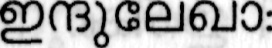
ഇന്ദുലേഖാ:
